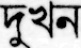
দুখন
